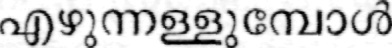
എഴുന്നള്ളുമ്പോള്‍
